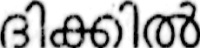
ദിക്കില്‍
